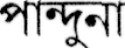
পান্দুনা
